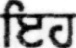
ਇਹ
